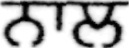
ਨਾਲ
